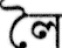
লৈ
